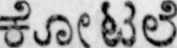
ಕೋಟಲೆ
